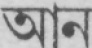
আন
